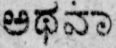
ಅಥವಾ
